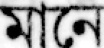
মানে
